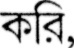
করি,
